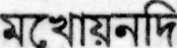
মখোয়নদি
